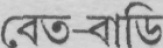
বেত-বাড়ি
